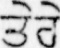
ਤੇਰੇ
